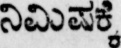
ನಿಮಿಷಕ್ಕೆ
